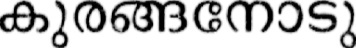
കുരങ്ങനോടു
